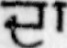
ਦਾ
